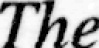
The
